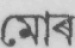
মোৰ
